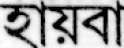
হায়বা
